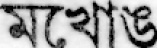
মখোঙ
